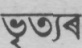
ভৃত্যৰ
